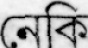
নেকি
